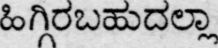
ಹಿಗ್ಗಿರಬಹುದಲ್ಲಾ
